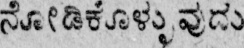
ನೋಡಿಕೊಳ್ಳುವುದು
